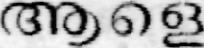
ആളെ
